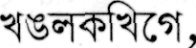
খঙলকখিগে,
